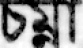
চম্না
